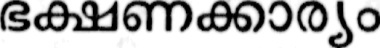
ഭക്ഷണക്കാര്യം
